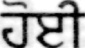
ਹੋਈ
